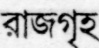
রাজগৃহ
